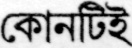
কোনটিই
